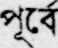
পূর্বে
